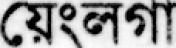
য়েংলগা
